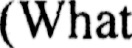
(What
